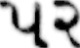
પર
